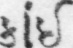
કાંઈ
